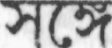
সঙ্গে
